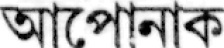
আপোনাক
